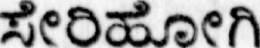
ಸೇರಿಹೋಗಿ
